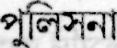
পুলিসনা
